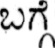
ಬಗ್ಗೆ
